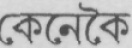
কেনেকৈ
